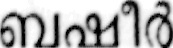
ബഷീര്‍
